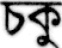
চকু
